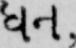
ધન,
